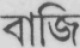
বাজি
